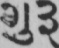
ગુરૂ
